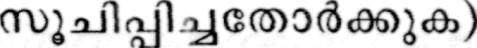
സൂചിപ്പിച്ചതോര്‍ക്കുക)
